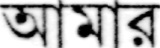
আমার
